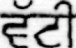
ਵੱਟੀ
